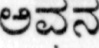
ಅವನ
